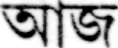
আজ
